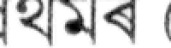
প্ৰথমৰ
